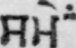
ਸਮੇਂ
